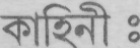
কাহিনীঃ
